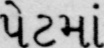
પેટમાં
